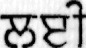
ਲਈ
